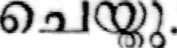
ചെയ്തു.
